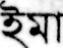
ইমা
